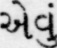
એવું
